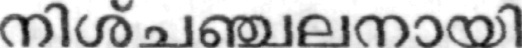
നിശ്ചഞ്ചലനായി
